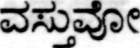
ವಸ್ತುವೋ
